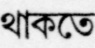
থাকতে
